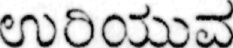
ಉರಿಯುವ
